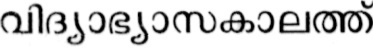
വിദ്യാഭ്യാസകാലത്ത്
